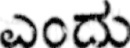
ಎಂದು
